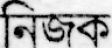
নিজক
